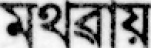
মথৱায়
